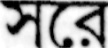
সরে
